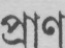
প্ৰাণ
